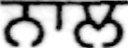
ਨਾਲ
